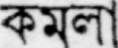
কমলা
